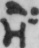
ਮੈਂ
